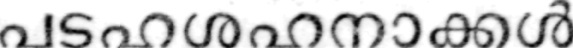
പടഹശഹനാക്കള്‍
